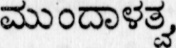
ಮುಂದಾಳತ್ವ
